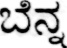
ಬೆನ್ನ
